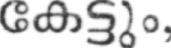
കേട്ടും,
